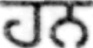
ਹਨ
